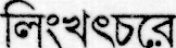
লিংখৎচরে
